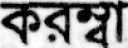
করম্বা
